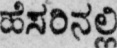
ಹೆಸರಿನಲ್ಲಿ
